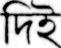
দিই
